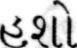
હશો
